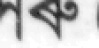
সৰু
